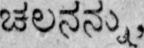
ಚಲನನ್ನು,
